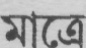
মাত্ৰে
